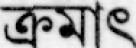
ক্রমাৎ
